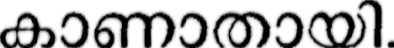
കാണാതായി.
